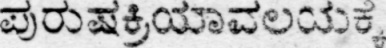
ಪುರುಷಕ್ರಿಯಾವಲಯಕ್ಕೆ
